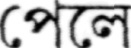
পেলে
